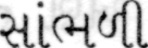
સાંભળી
